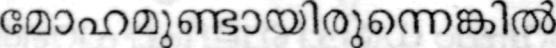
മോഹമുണ്ടായിരുന്നെങ്കില്‍
